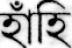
হাঁহি
